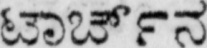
ಟಾರ್ಚ್‌ನ
